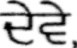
ਦੇਵੇ,
